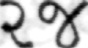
રજ
